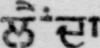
ਲੈਂਦਾ
